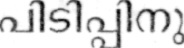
പിടിപ്പിനു
